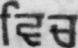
ਵਿਚ
